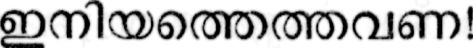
ഇനിയത്തെത്തവണ!
